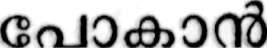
പോകാന്‍
